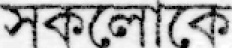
সকলোকে
